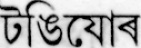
টঙিযোৰ
